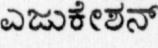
ಎಜುಕೇಶನ್
